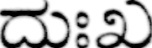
ದುಃಖ
